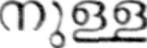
നുള്ള
